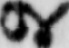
જ
